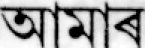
আমাৰ
